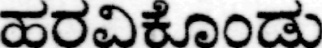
ಹರವಿಕೊಂಡು
